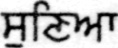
ਸੁਣਿਆ
